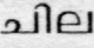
ചില
